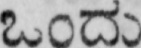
ಒಂದು
